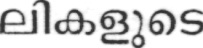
ലികളുടെ
